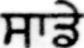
ਸਾਡੇ
